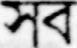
সব
